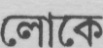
লোকে
